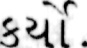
કર્યો.
